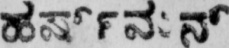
ಹರ್ಷಮನ್
